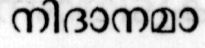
നിദാനമാ
